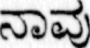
ನಾವು
